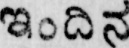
ಇಂದಿನ
